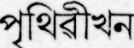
পৃথিৱীখন
